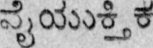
ವೈಯುಕ್ತಿಕ
